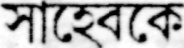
সাহেবকে
